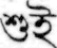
শুই
